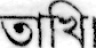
তাখি।
